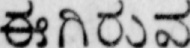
ಈಗಿರುವ
